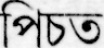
পিচত
